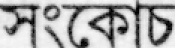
সংকোচ
